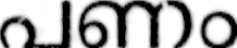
പണം
